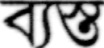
ব্যস্ত
